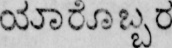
ಯಾರೊಬ್ಬರ
